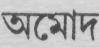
অমোদ
